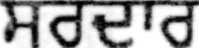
ਸਰਦਾਰ
